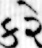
કરે
